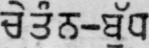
ਚੇਤੰਨ-ਬੁੱਧ
